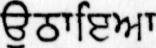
ਉਠਾਇਆ
